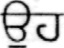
ਉਹ
